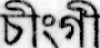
চীংগী
